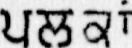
ਪਲਕਾਂ
